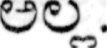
ಅಲ್ಲ.
